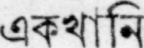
একখানি
